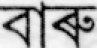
বাৰু
